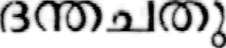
ദന്തചതു
